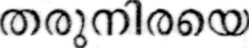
തരുനിരയെ
